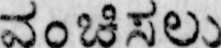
ವಂಚಿಸಲು
